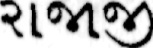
રાજાજી
